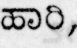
ಹಾರಿ,
